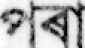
পৰা
